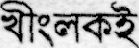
খীংলকই
